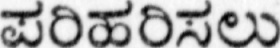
ಪರಿಹರಿಸಲು
